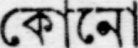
কোনো
